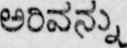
ಅರಿವನ್ನು
